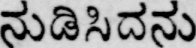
ನುಡಿಸಿದನು
